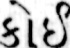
કોઈ
